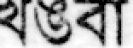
খঙবা
